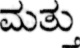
ಮತ್ತು
